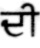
ਦੀ
